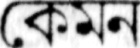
কেমন
